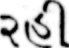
રહી
